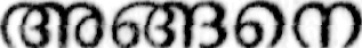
അങ്ങനെ
